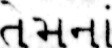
તેમનાં
